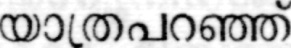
യാത്രപറഞ്ഞ്
